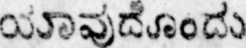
ಯಾವುದೊಂದು
